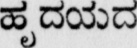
ಹೃದಯದ
